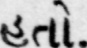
હતો.
